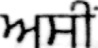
ਅਸੀਂ
